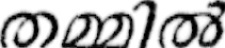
തമ്മില്‍
